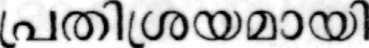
പ്രതിശ്രയമായി
